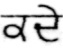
ਕਦੇ
